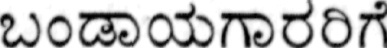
ಬಂಡಾಯಗಾರರಿಗೆ
